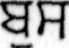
ਬੁਸ
